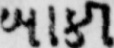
બાકી
